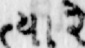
ત્યારે
